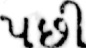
પછી
